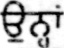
ਉਨ੍ਹਾਂ
